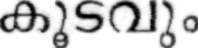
കൂടവും
